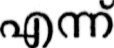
എന്ന്
